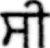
ਸੀ
